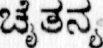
ಚೈತನ್ಯ
